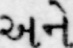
અને
